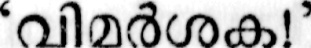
'വിമര്‍ശക!'
